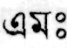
এমঃ
